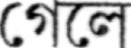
গেলে
